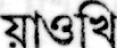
য়াওখি
